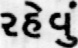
રહેવું
